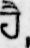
ਹੈ,
